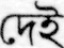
দেই
